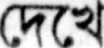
দেখে
